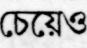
চেয়েও
